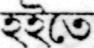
হইতে
